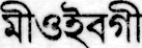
মীওইবগী
